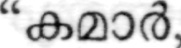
“കമാര്‍,
